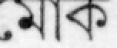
মোক
